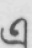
এ
